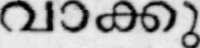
വാക്കു
